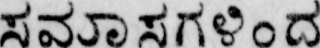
ಸಮಾಸಗಳಿಂದ
